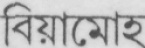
বিয়ামোহ
